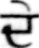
ਦੇ
